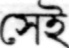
সেই
